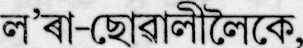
ল'ৰা-ছোৱালীলৈকে,
